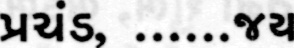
પ્રચંડ,......જય
